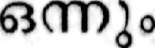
ഒന്നും
